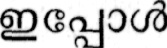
ഇപ്പോള്‍
